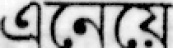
এনেয়ে
